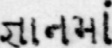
જ્ઞાનમાં
